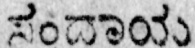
ಸಂದಾಯ
